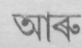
আৰু
